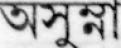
অসুম্না
